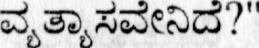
ವ್ಯತ್ಯಾಸವೇನಿದೆ?”
